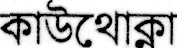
কাউথোক্না
